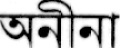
অনীনা
